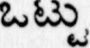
ಒಟ್ಟು
